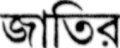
জাতির
